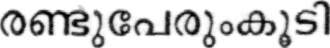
രണ്ടുപേരുംകൂടി
